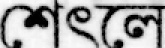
শেৎলে
